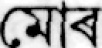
মোৰ
